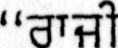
''ਰਾਜੀ
